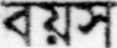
বয়স
